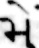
મેં
